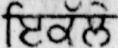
ਇਕੱਲੇ
